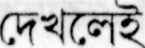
দেখলেই
